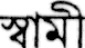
স্বামী
